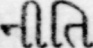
નીતિ
